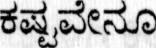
ಕಷ್ಟವೇನೂ
